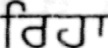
ਰਿਹਾ
